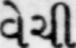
વેચી
